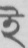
ই
